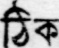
ঠিক
